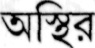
অস্থির
